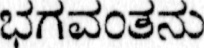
ಭಗವಂತನು
